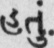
હતું.
